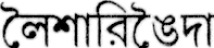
লৈশারিঙৈদা
